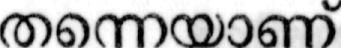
തന്നെയാണ്
